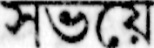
সভয়ে
